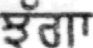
ਝੱਗਾ
